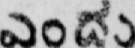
ಎಂದು
